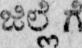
ಜಿಲ್ಲೆಗೆ
